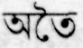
অতৈ
